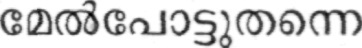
മേല്‍പോട്ടുതന്നെ
